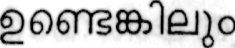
ഉണ്ടെങ്കിലും
